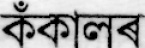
কঁকালৰ
